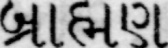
બ્રાહ્મણ
